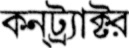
কন্ট্র্যাক্টর
